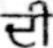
ਦੀ
